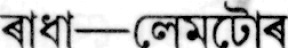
ৰাধা-লেমটোৰ
